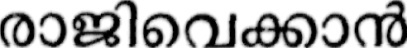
രാജിവെക്കാന്‍
